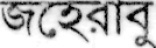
জহেরাবু
